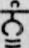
ਨੂੰ
